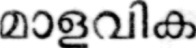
മാളവിക
